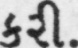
કરી.
